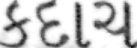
કદાચ
